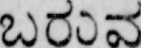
ಬರುವ
